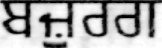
ਬਜ਼ੁਰਗ
